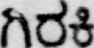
ಗಿರಿಕಿ
